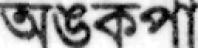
অঙকপা
